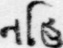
નહિ
